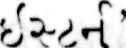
ઇસ્ટર્ન'
